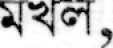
মখল,
